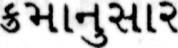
ક્રમાનુસાર
